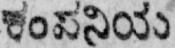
ಕಂಪನಿಯ
